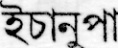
ইচানুপা
